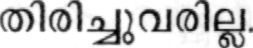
തിരിച്ചുവരില്ല.
